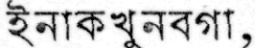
ইনাকখুনবগা,
